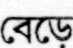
বেড়ে
